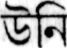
উনি
